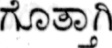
ಗೊತ್ತಾಗಿ
